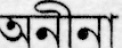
অনীনা
